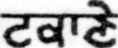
ਟਕਾਣੇ
